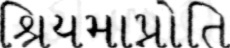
શ્રિયમાપ્રોતિ
